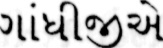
ગાંધીજીએ
